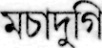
মচাদুগি
